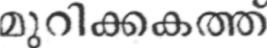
മുറിക്കകത്ത്
